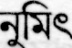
নুমিৎ
